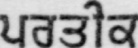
ਪਰਤੀਕ
